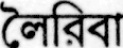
লৈরিবা
